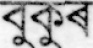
বুকুৰ
